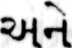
અને
